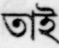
তাই
